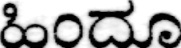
ಹಿಂದೂ
